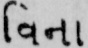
વિના
